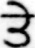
ਤੇ
